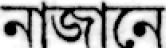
নাজানে
